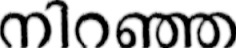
നിറഞ്ഞ
